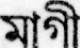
মাগী
